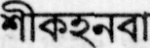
শীকহনবা
